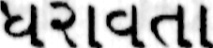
ધરાવતા
